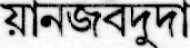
য়ানজবদুদা
